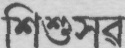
শিশুসৱ
